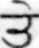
ਤੇ
